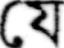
যে
